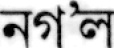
নগ'ল
